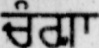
ਚੰਗਾ
